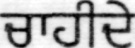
ਚਾਹੀਦੇ
